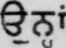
ਉਨ੍ਹਾਂ
